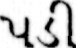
પડી
